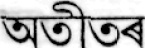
অতীতৰ
